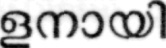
ളനായി
